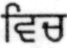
ਵਿਚ
